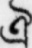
ঐ
